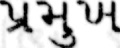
પ્રમુખ
